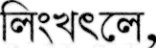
লিংখৱলে,
